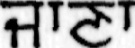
ਜਾਣਾ
